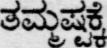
ತಮ್ಮಷ್ಟಕ್ಕೆ
